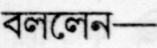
বললেন–
